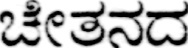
ಚೇತನದ
